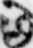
છે
